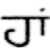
ਹਾਂ
